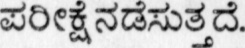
ಪರೀಕ್ಷೆನಡೆಸುತ್ತದೆ.
